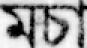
মচা
